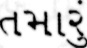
તમારું
